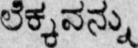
ಲೆಕ್ಕವನ್ನು
